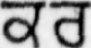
ਕਰ
